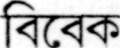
বিবেক
